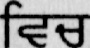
ਵਿਚ
